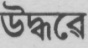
উদ্ধৱে
